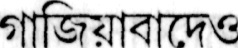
গাজিয়াবাদেও
